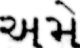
અમે
